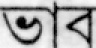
ভাব
